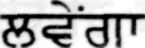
ਲਵੇਂਗਾ
